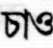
চাও
